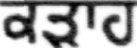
ਕੜਾਹ
